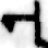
ન
